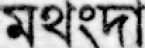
মথংদা
